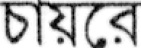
চায়রে
